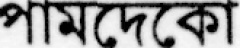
পামদেকো
